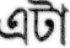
এটা
